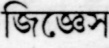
জিজ্ঞেস
